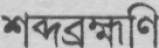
শব্দব্ৰহ্মণি
